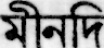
মীনদি
